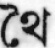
থৈ
